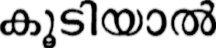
കൂടിയാല്‍
